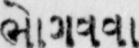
ભોગવવા
